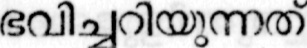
ഭവിച്ചറിയുന്നത്
